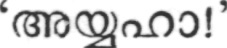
‘അയ്യഹാ!'
